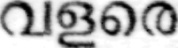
വളരെ
